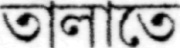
তালাতে
